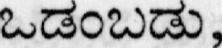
ಒಡಂಬಡು,
